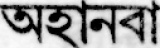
অহানবা
